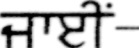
ਜਾਈਂ-
